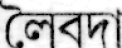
লৈবদা
